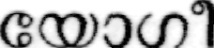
യോഗീ
